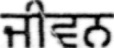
ਜੀਵਨ
